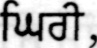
ਘਿਰੀ,
